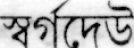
স্বর্গদেউ
